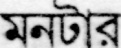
মনটার
